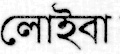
লোইবা
